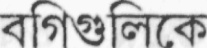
বগিগুলিকে
